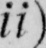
ii)
